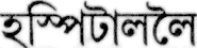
হস্পিটাললৈ
